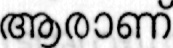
ആരാണ്
